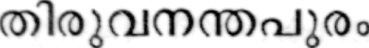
തിരുവനന്തപുരം
